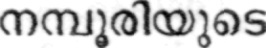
നമ്പൂരിയുടെ
